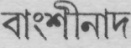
বাংশীনাদ
